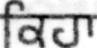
ਕਿਹਾ
